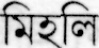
মিহলি
